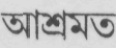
আশ্রমত
